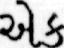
એક
